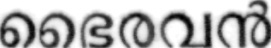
ഭൈരവന്‍
